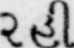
રહી
